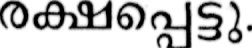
രക്ഷപ്പെട്ടു.
